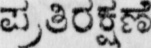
ಪ್ರತಿರಕ್ಷಣೆ
